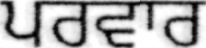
ਪਰਵਾਰ
